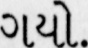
ગયો.
